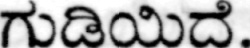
ಗುಡಿಯಿದೆ.
